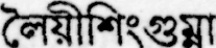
লৈয়ীশিংগুম্না
